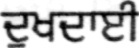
ਦੁਖਦਾਈ
